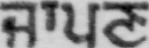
ਜਾਪਣ
